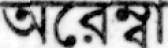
অরেম্বা
